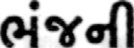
ભંજની
